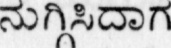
ನುಗ್ಗಿಸಿದಾಗ
